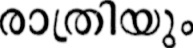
രാത്രിയും
